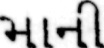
માની
